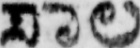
ಸಾಲ
